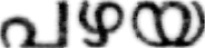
പഴയ
